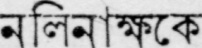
নলিনাক্ষকে
